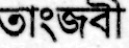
তাংজবী
